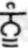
ਨੂੰ
